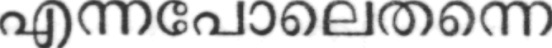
എന്നപോലെതന്നെ
